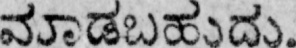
ಮಾಡಬಹುದು.
